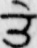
ਤੇ
